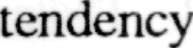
tendency
